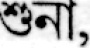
শুনা,
